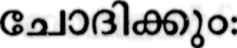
ചോദിക്കും:
